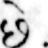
છે.
